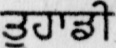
ਤੁਹਾਡੀ
